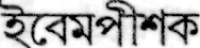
ইবেমপীশক
